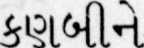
કણબીને
